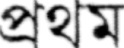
প্রথম
